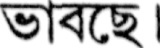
ভাবছে।
